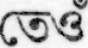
তেওঁ
